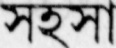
সহসা
